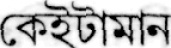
কেইটামান
